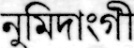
নুমিদাংগী
